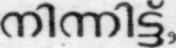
നിന്നിട്ട്,
